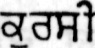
ਕੁਰਸੀ
